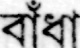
বাঁধা
